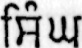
ਸਿੰਘ
